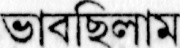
ভাবছিলাম
